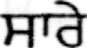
ਸਾਰੇ
